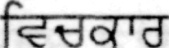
ਵਿਚਕਾਰ
